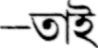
-তাই
